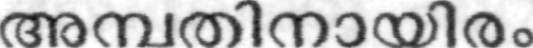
അമ്പതിനായിരം
